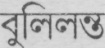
বুলিলন্ত
